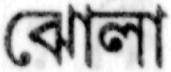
ঝোলা
